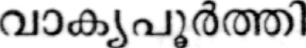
വാക്യപൂര്‍ത്തി
